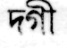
দগী
